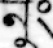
নুং
